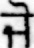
ਜੋ
